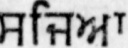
ਸਜਿਆ
